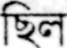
ছিল
